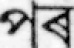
পৰ
